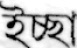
ইচ্ছা
